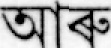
আৰু
